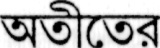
অতীতের
